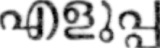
എളുപ്പ
